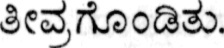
ತೀವ್ರಗೊಂಡಿತು.
